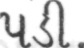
પડી.
